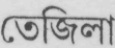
তেজিলা
